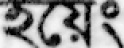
হয়েং
